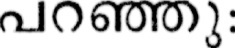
പറഞ്ഞു:
